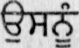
ਉਸਨੂੰ
